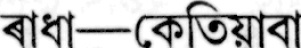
ৰাধা-কেতিয়াবা
